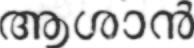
ആശാന്‍
